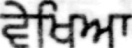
ਵੇਖਿਆ
